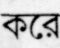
করে
